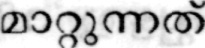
മാറ്റുന്നത്
